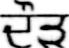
ਦੌੜ
